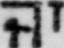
ਜਾ
